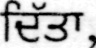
ਦਿੱਤਾ,
